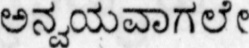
ಅನ್ವಯವಾಗಲೇ
